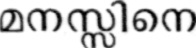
മനസ്സിനെ
